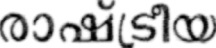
രാഷ്ട്രീയ
